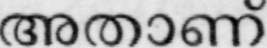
അതാണ്
